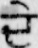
ਦੇ
